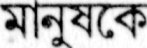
মানুষকে
